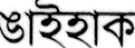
ঙাইহাক
